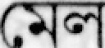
মেল
